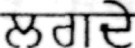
ਲਗਦੇ
